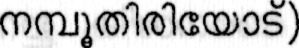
നമ്പൂതിരിയോട്)
